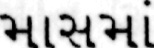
માસમાં
